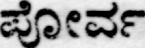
ಪೋರ್ವ
